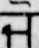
ਜੋ
